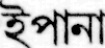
ইপানা
